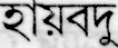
হায়বদু
